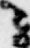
કે
